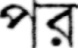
পর
